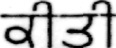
ਕੀਤੀ
